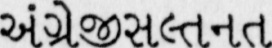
અંગ્રેજીસલ્તનત
